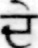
ਦੇ
